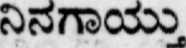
ನಿನಗಾಯ್ತು
